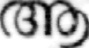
ആ
